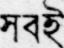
সবই
